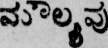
ಮೌಲ್ಯವು
